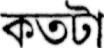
কতটা
